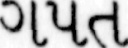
ગપત
